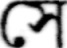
সে
